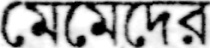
মেমেদের
